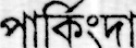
পার্কিংদা
